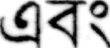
এবং
